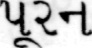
પૂરન
